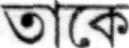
তাকে
